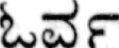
ಓರ್ವ
